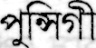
পুন্সিগী
